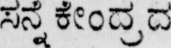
ಸನ್ನೆಕೇಂದ್ರದ
